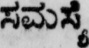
ಸಮಸ್ಯೆ
